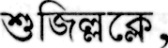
শুজিল্লক্লে,
